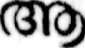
ആ
